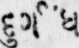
દુર્ગંધ
